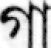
গা
